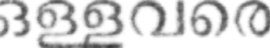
ഒള്ളവരെ
